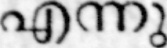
എന്നു
